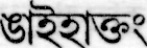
ঙাইহাক্তং
